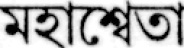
মহাশ্বেতা
